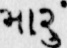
મારું
